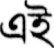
এই
